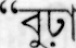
"বুঢ়া
